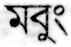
মবুং
